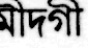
মীদগী
